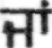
ਜਾਂ
